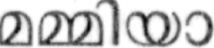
മമ്മിയാ
